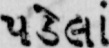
પડેલાં
